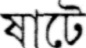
ষাটে
